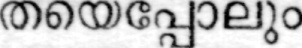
തയെപ്പോലും
